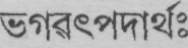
ভগৱৎপদাৰ্থঃ
